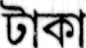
টাকা
